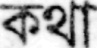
কথা
